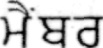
ਮੈਂਬਰ
